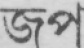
জপ
